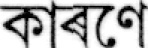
কাৰণে
